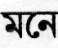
মনে
